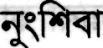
নুংশিবা
